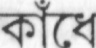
কাঁধে
